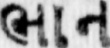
ભાન
